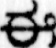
ಈ
